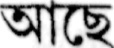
আছে
